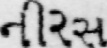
નીરસ
